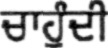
ਚਾਹੁੰਦੀ
